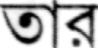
তার
